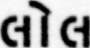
લોલ
